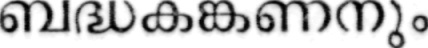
ബദ്ധകങ്കണനും
